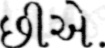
છીએ.
